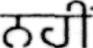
ਨਹੀਂ
